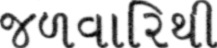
જળવારિથી
